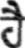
ਹੈ
